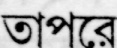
তাপরে
